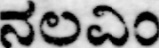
ನಲವಿ೦
